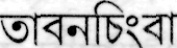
তাবনচিংবা
